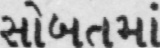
સોબતમાં
